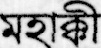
মহাক্কী
